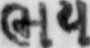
ભય
